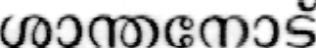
ശാന്തനോട്
